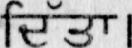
ਦਿੱਤਾ।
